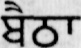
ਬੈਠਾ
